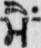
ਮੈਂ
